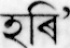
হৰি'
